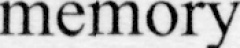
memory
